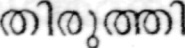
തിരുത്തി
